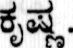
ಕೃಷ್ಣ.
